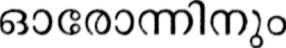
ഓരോന്നിനും
